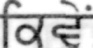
ਕਿਵੇਂ
